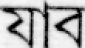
যাব
